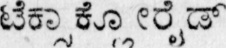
ಟೆಕ್ಸಾಕ್ಲೋರೈಡ್‌
